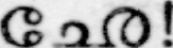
ഛേ!
